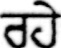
ਰਹੇ
